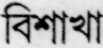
বিশাখা
